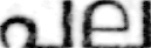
പല
